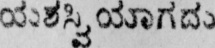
ಯಶಸ್ವಿಯಾಗದು
